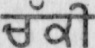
ਚੱਕੀ
